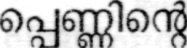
പ്പെണ്ണിന്റെ
